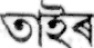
তাইৰ
